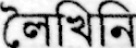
লৈখিনি
